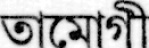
তামোগী
